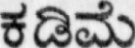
ಕಡಿಮೆ
